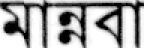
মান্নবা
